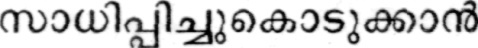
സാധിപ്പിച്ചുകൊടുക്കാന്‍
